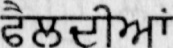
ਫੈਲਦੀਆਂ
